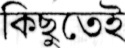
কিছুতেই
